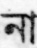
না
